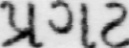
પ્રગટ
